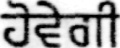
ਹੋਵੇਗੀ
